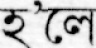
হ'লে
